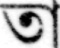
তা
